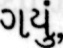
ગયું,
